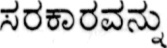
ಸರಕಾರವನ್ನು
